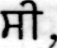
ਸੀ,
